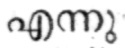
എന്നു
